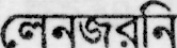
লেনজরনি
